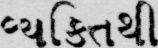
વ્યક્તિથી
